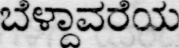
ಬೆಳ್ದಾವರೆಯ
